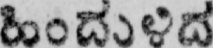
ಹಿಂದುಳಿದ
